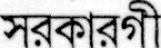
সরকারগী
